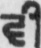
ਵੀ
